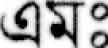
এমঃ
